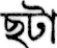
ছটা
